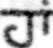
ਹਾਂ
